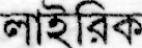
লাইরিক
